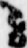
કે
